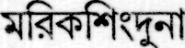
মরিকশিংদুনা
